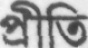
প্রীতি
